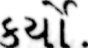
કર્યો.
